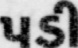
પડી
